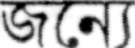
জন্যে
